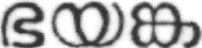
ഭയങ്ക
